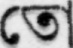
তো
